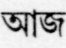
আজ
